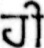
ਹੀ
